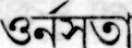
ওর্নসতা
